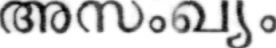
അസംഖ്യം
